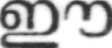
ഈ
